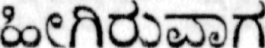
ಹೀಗಿರುವಾಗ
